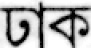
ঢাক
